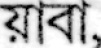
য়াবা,
